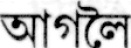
আগলৈ
